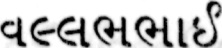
વલ્લભભાઈ
